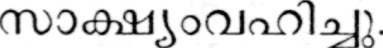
സാക്ഷ്യംവഹിച്ചു.
